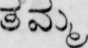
ತಮ್ಮ
